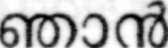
ഞാന്‍
